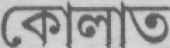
কোলাত
